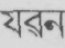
যৱন
